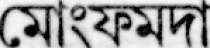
মোংফমদা
